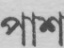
পাশ
